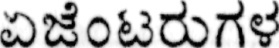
ಏಜೆಂಟರುಗಳ
